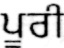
ਪੂਰੀ
